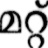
മറ്റ്
